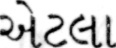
એટલા
